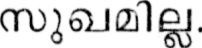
സുഖമില്ല.
